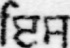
ਇਸ
